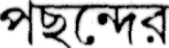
পছন্দের
